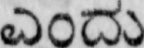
ಎಂದು
